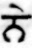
ਨੇ
